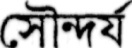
সৌন্দর্য
